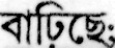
বাঢ়িছে;
